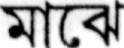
মাঝে
